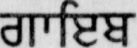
ਗਾਇਬ
